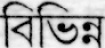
বিভিন্ন
